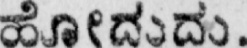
ಹೋದುದು.
